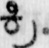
ಕ್ರಿ.
